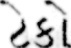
ટેકો
